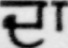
ਦਾ
